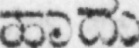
ಹಾದು
